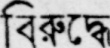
বিরুদ্ধে
